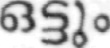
ഒട്ടും
